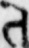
તે
